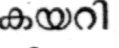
കയറി
